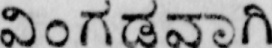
ವಿಂಗಡವಾಗಿ
